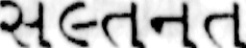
સલ્તનત
